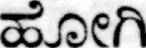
ಹೋಗಿ
